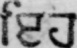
ਇਹ
